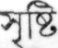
সৃষ্টি
